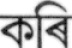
কৰি
